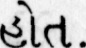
હોત.
